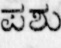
ಪಶು
